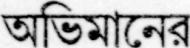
অভিমানের
